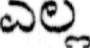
ಎಲ್ಲ
